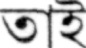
তাই
